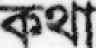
কথা
